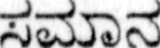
ಸಮಾನ
